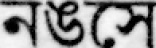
নঙসে
